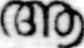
ആ
